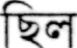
ছিল
